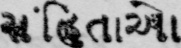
સ્રંહિતાઓ
